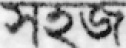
সহজ
